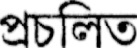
প্রচলিত
